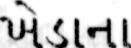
ખેડાના
